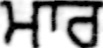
ਮਾਰ
